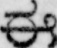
ಈ
